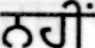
ਨਹੀਂ
